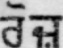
ਰੋਜ਼
